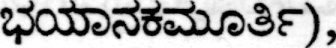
ಭಯಾನಕಮೂರ್ತಿ),
